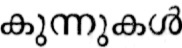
കുന്നുകള്‍
